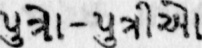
પુત્રો-પુત્રીઓ
